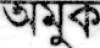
অমুক
